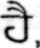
ਹੈ,
